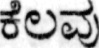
ಕೆಲವು
